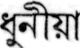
ধুনীয়া
